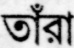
তাঁরা
